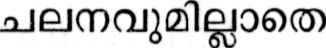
ചലനവുമില്ലാതെ
